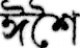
ঈশৈ
